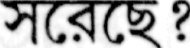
সরেছে?
